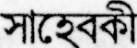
সাহেবকী
